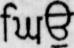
ਘਿਉ
